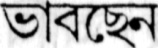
ভাবছেন
